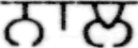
ਨਾਲ
